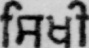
ਸਿਖੀ
